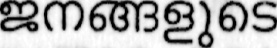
ജനങ്ങളുടെ
